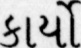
કાર્યો
